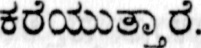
ಕರೆಯುತ್ತಾರೆ.
